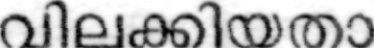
വിലക്കിയതാ
